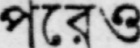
পরেও
